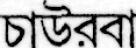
চাউরবা
